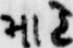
માટે
